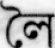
লৈ
